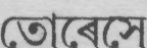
তোৰেসে
